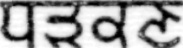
ਧੜਕਣ
